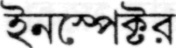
ইনস্পেক্টর
